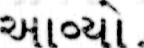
આવ્યો.
